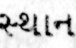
સ્થાન
